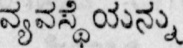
ವ್ಯವಸ್ಥೆಯನ್ನು
